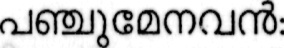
പഞ്ചുമേനവന്‍:
